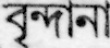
বৃন্দানা
